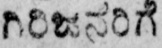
ಗಿರಿಜನರಿಗೆ
